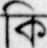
কি
